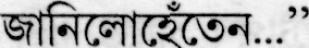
জানিলোহেঁতেন..."
